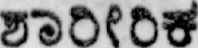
ಶಾರೀರಿಕ
